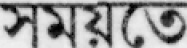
সময়তে
